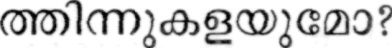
ത്തിന്നുകളയുമോ?
